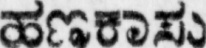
ಹಣಕಾಸು
